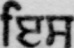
ਇਸ
